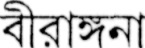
বীরাঙ্গনা
